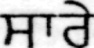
ਸਾਰੇ
